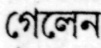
গেলেন
